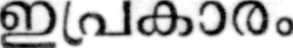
ഇപ്രകാരം
